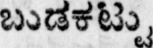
ಬುಡಕಟ್ಟು
